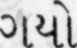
ગયો
